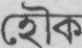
হৌক
